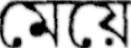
মেয়ে
